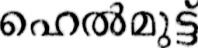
ഹെല്‍മുട്ട്
